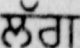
ਲੱਗ
